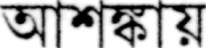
আশঙ্কায়
